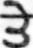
ਤੇ
